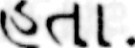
હતા.
